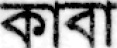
কাবা
